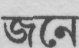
জনে
